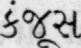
કંજૂસ
